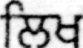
ਲਿਖ
